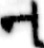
ન
